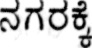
ನಗರಕ್ಕೆ
